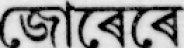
জোৰেৰে
